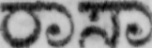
ರಾಸಾ
